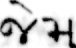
જેમ
